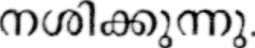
നശിക്കുന്നു.
